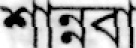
শান্নাবা
